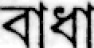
বাধা
